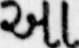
આ
